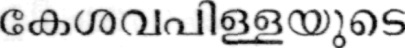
കേശവപിള്ളയുടെ
